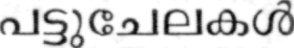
പട്ടുചേലകള്‍
